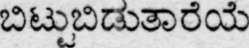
ಬಿಟ್ಟುಬಿಡುತಾರೆಯೆ
